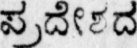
ಪ್ರದೇಶದ
